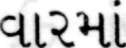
વારમાં
